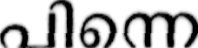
പിന്നെ
